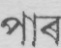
পাৰ
